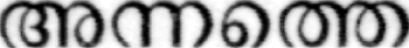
അന്നത്തെ
